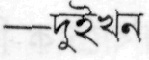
-দুইখুন
